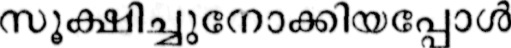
സൂക്ഷിച്ചുനോക്കിയപ്പോള്‍
